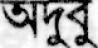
অদুবু
